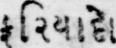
યે
